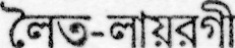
লৈত-লায়রগী
